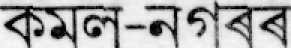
কমল-নগৰৰ
